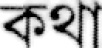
কথা
